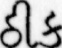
ઠીક
